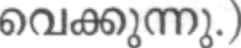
വെക്കുന്നു.)
